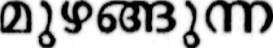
മുഴങ്ങുന്ന
